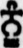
ਨੂੰ
